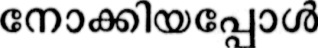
നോക്കിയപ്പോള്‍
